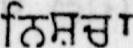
ਨਿਸ਼ਚਾ
